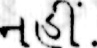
નહીં.
